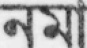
নমা
